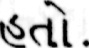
હતો.
